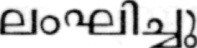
ലംഘിച്ചു
